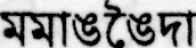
মমাঙঙৈদা
